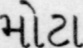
મોટા
